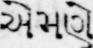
એમણે
